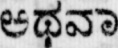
ಅಥವಾ
